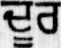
ਦੂਰ
